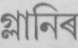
গ্নানিৰ
